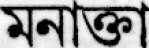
মনাক্তা
